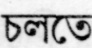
চলতে
